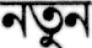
নতুন
